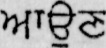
ਆਉਣ
